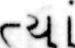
ત્યાં
